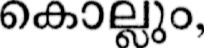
കൊല്ലും,
